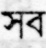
সব
